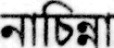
নাচিন্না
